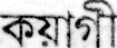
কয়াগী
